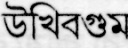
উখিবগুম
